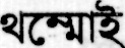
থম্মোই
